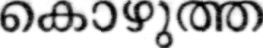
കൊഴുത്ത
